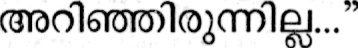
അറിഞ്ഞിരുന്നില്ല...”
